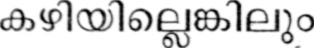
കഴിയില്ലെങ്കിലും
